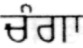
ਚੰਗਾ
